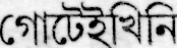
গোটেইখিনি
